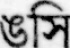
ঙসি
